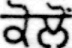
ਕੋਲੋਂ
